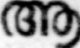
ആ
